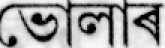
ভোলাৰ
